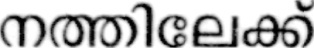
നത്തിലേക്ക്
